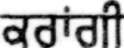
ਕਰਾਂਗੀ
